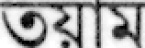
তয়াম
